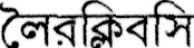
লৈরক্লিবসি
